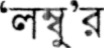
‘লম্বু’র
